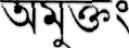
অমুক্তং
